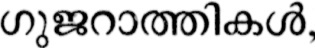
ഗുജറാത്തികള്‍,
